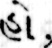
હો,
